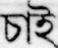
চাই
